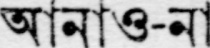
আনাও-না
